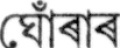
ঘোঁৰাৰ
